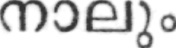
നാലും
